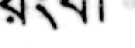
য়ংবা
